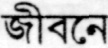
জীবনে
